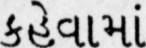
કહેવામાં
